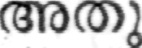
അതു
